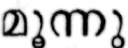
മൂന്നു
